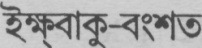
ইক্ষ্‌বাকু-বংশত
